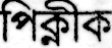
পিক্নীক
